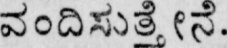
ವಂದಿಸುತ್ತೇನೆ.
